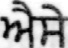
ਐਸੇ
